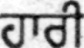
ਹਾਰੀ
